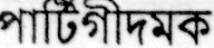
পার্টিগীদমক
